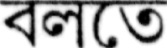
বলতে
